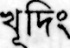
খূদিং
